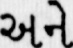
અને
